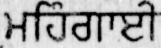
ਮਹਿੰਗਾਈ
